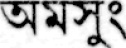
অমসুং
